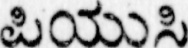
ಪಿಯುಸಿ
